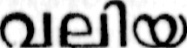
വലിയ
